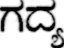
ಗದ್ಯ
